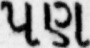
પણ
